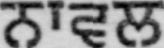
ਨਾਵਲ
